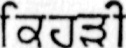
ਕਿਹੜੀ
